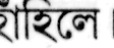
হাঁহিলে
